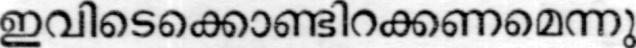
ഇവിടെക്കൊണ്ടിറക്കണമെന്നു
